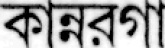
কান্নরগা
